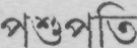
পশুপতি
